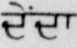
ਦੇਂਦਾ
